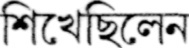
শিখেছিলেন
